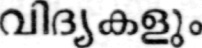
വിദ്യകളും
